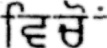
ਵਿਚੋਂ
